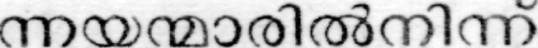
ന്നയന്മാരില്‍നിന്ന്
